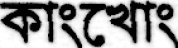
কাংখোং
